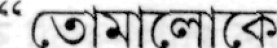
"তোমালোকে
